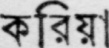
করিয়া
